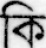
কি
